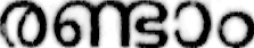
രണ്ടാം
